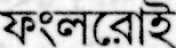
ফংলরোই
